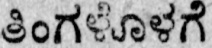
ತಿಂಗಳೊಳಗೆ
